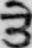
ਤੇ
